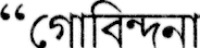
“গোবিন্দনা
